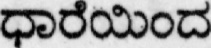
ಧಾರೆಯಿಂದ
